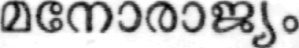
മനോരാജ്യം
